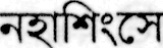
নহাশিংসে
